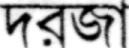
দরজা
